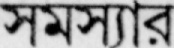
সমস্যার
